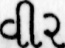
વીર
